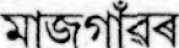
মাজগাঁৱৰ
